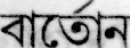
বার্তোন
